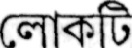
লোকটি
